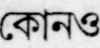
কোনও
